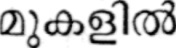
മുകളില്‍
